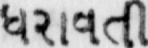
ધરાવતી
